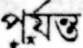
পর্যন্ত
